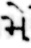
મેં
